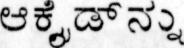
ಆಕ್ಸೈಡ್‌ನ್ನು
